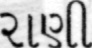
રાણી
